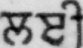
ਲਈ
